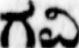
ಗವಿ
